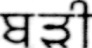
ਬੜੀ
